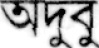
অদুবু
